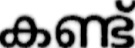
കണ്ട്
